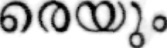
രെയും
